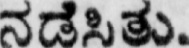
ನಡೆಸಿತು.
